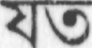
যত
